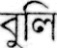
বুলি
